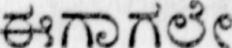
ಈಗಾಗಲೇ
